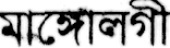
মাঙ্গোলগী
